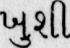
ખુશી
